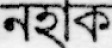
নহাক
